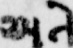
અને
